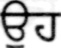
ਉਹ
